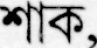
শাক,
